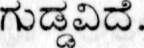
ಗುಡ್ಡವಿದೆ.
